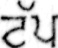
ਟੱਪ
